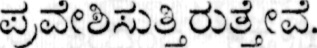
ಪ್ರವೇಶಿಸುತ್ತಿರುತ್ತೇವೆ.
